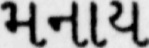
મનાય
